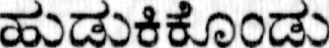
ಹುಡುಕಿಕೊಂಡು
